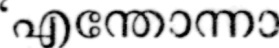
‘എന്തോന്നാ
